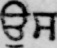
ਉਸ
